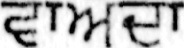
ਵਾਅਦਾ
